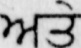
ਅਤੇ
